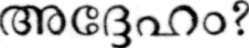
അദ്ദേഹം?
